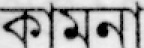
কামনা
